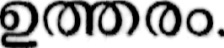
ഉത്തരം.
